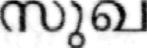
സുഖ
